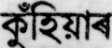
কুঁহিয়াৰ
